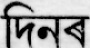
দিনৰ
